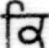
ਕਿ
